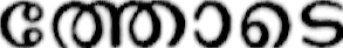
ത്തോടെ
